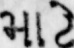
માટે
